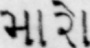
મારો
